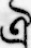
ঐ
